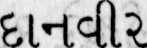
દાનવીર
